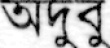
অদুবু
